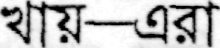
খায়—এরা
